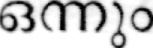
ഒന്നും
